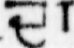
ਦਾ
